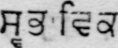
ਸ੍ਵਭਾਵਿਕ
